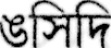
ঙসিদি
